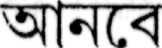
আনবে
